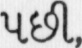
પછી,
